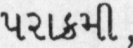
પરાક્રમી,
